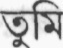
তুমি
